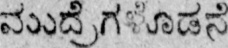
ಮುದ್ರೆಗಳೊಡನೆ
